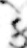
કે
